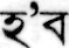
হ'ব
